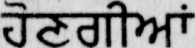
ਹੋਣਗੀਆਂ
